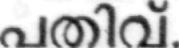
പതിവ്.
